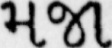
મજા
